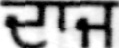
ਦਾਜ
